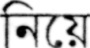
নিয়ে
